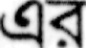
এর
